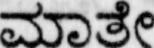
ಮಾತೇ
